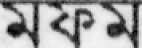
মফম
